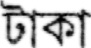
টাকা
